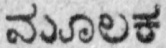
ಮೂಲಕ
